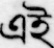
এই
